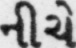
નીચે
